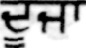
ਦੂਜਾ
